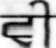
ਵੀ
